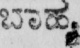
ಬಾಹ್ಯ
